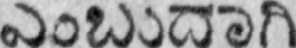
ಎಂಬುದಾಗಿ
